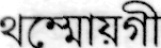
থম্মোয়গী
